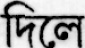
দিলে
